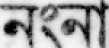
নংনা
